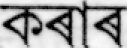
কৰাৰ
